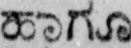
ಹಾಗೂ
